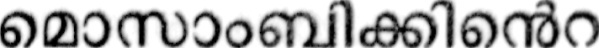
മൊസാംബിക്കിന്റെ
